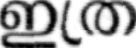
ഇത്ര
